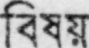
বিষয়
